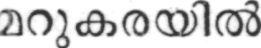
മറുകരയില്‍
